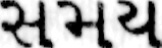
સમય
